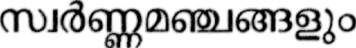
സ്വര്‍ണ്ണമഞ്ചങ്ങളും
